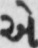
એ
